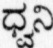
ಧ್ವನಿ
